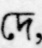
দে,
